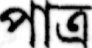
পাত্র
